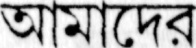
আমাদের
